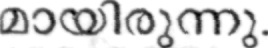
മായിരുന്നു.
